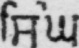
ਸਿੰਘ
